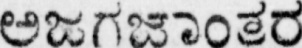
ಅಜಗಜಾಂತರ
